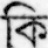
কি
